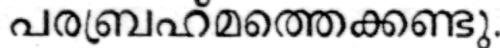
പരബ്രഹ്മത്തെക്കണ്ടു.
